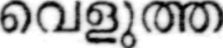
വെളുത്ത
